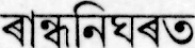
ৰান্ধনিঘৰত
